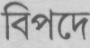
বিপদে
